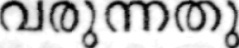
വരുന്നതു
